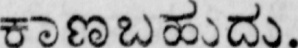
ಕಾಣಬಹುದು.
